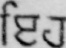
ਇਹ
